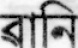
ৱানি
